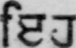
ਇਹ
